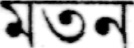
মতন
